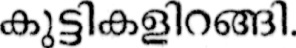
കുട്ടികളിറങ്ങി.
